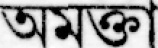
অমক্তা
